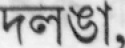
দলঙা,
